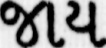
જાય
